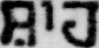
ਸ਼ਾਹ
